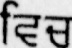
ਵਿਚ
